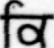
ਕਿ
